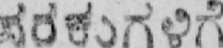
ಸರಕುಗಳಿಗೆ
